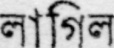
লাগিল
